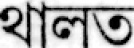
থালত
